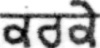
ਕਰਕੇ
